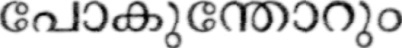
പോകുന്തോറും
